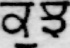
ਕੁਝ
